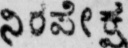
ನಿರಪೇಕ್ಷ
